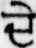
ਦੇ
